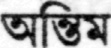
অন্তিম
